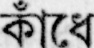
কাঁধে
